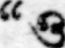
‘‘ও
